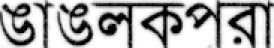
ঙাঙলকপরা
